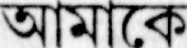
আমাকে
